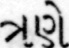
ત્રણે
